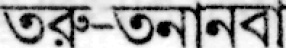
তরু-তনানবা
